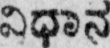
ವಿಧಾನ
